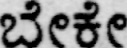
ಬೇಕೇ
